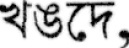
খঙদে,
